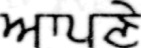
ਆਪਣੇ
